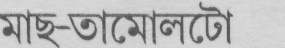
মাছ-তামোলটো
